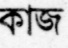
কাজ
